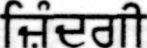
ਜ਼ਿੰਦਗੀ
